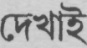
দেখাই
